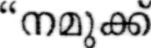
“നമുക്ക്
